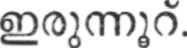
ഇരുന്നൂറ്.
